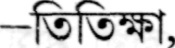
-তিতিক্ষা,
